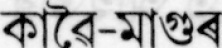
কাৱৈ-মাগুৰ
